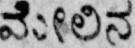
ಮೇಲಿನ
